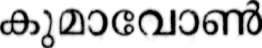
കുമാവോണ്‍
